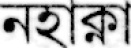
নহাক্না
